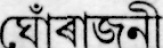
ঘোঁৰাজনী
